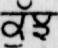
ਕੁੱਝ
